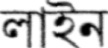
লাইন
